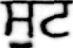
ਸੁਟ
